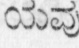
ಯವು
